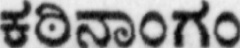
ಕಠಿನಾಂಗಂ
